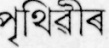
পৃথিৱীৰ
